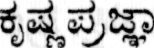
ಕೃಷ್ಣಪ್ರಜ್ಞಾ
